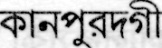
কানপুরদগী
